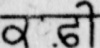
ਕਾਫ਼ੀ
